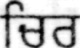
ਚਿਰ
